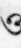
ও
